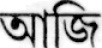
আজি
